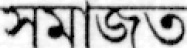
সমাজত
